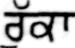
ਰੁੱਕਾ
